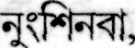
নুংশিনবা,
